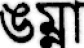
ঙম্না
